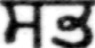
ਸਭ
